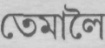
তেমালৈ
